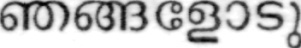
ഞങ്ങളോടു
